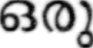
ഒരു
